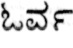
ಓರ್ವ
